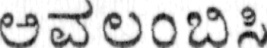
ಅವಲಂಬಿಸಿ
